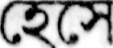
হেসে
